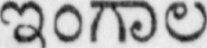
ಇಂಗಾಲ
